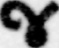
જ
